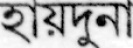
হায়দুনা
